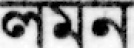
লমন
